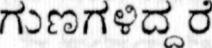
ಗುಣಗಳಿದ್ದರೆ
